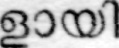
ളായി
